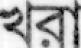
খরা
